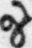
જે
